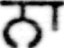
ਨਾ
